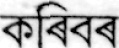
কৰিবৰ
